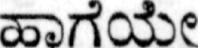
ಹಾಗೆಯೇ
